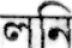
লনি
